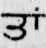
ਤਾਂ
